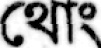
থোং
